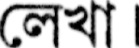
লেখা।
